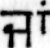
ਜਾਂ
